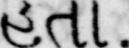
હતા.
